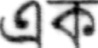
এক
